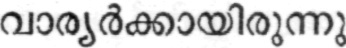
വാര്യര്‍ക്കായിരുന്നു.
